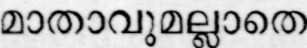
മാതാവുമല്ലാതെ
